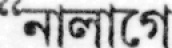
"নালাগে
